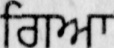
ਗਿਆ
